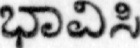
ಭಾವಿಸಿ
